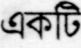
একটি
